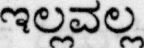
ಇಲ್ಲವಲ್ಲ
